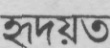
হৃদয়ত
